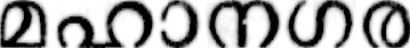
മഹാനഗര
